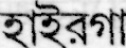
হাইরগা
